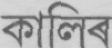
কালিৰ
